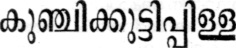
കുഞ്ചിക്കുട്ടിപ്പിള്ള
